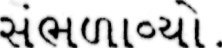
સંભળાવ્યો.
